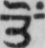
ਤੋਂ
